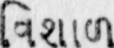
વિશાળ
